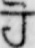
ਹੋ
